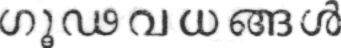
ഗൂഢവധങ്ങള്‍
